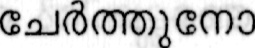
ചേര്‍ത്തുനോ
